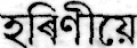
হৰিণীয়ে
